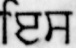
ਇਸ
